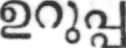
ഉറുപ്പ
